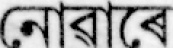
নোৱাৰে
